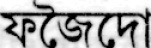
ফজৈদো
